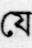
যে
